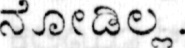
ನೋಡಿಲ್ಲ.
